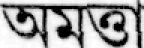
অমত্তা
